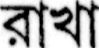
রাখা
